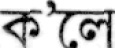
ক'লে
